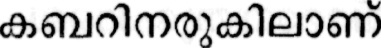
കബറിനരുകിലാണ്
